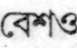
বেশও
